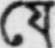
যে
